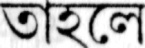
তাহলে
